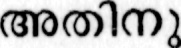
അതിനു
